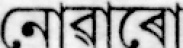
নোৱাৰো
